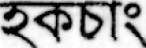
হকচাং
